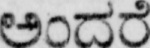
ಅಂದರೆ
